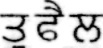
ਤੁਫੈਲ
